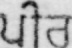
ਪੀਰ
